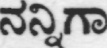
ನನ್ನಿಗಾ
